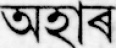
অহাৰ
